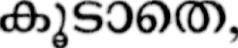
കൂടാതെ,
